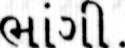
ભાંગી.
